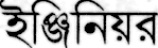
ইঞ্জিনিয়র
